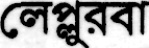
লেপ্লুরবা
